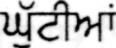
ਘੁੱਟੀਆਂ
